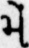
મેં
